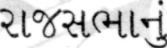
રાજસભાનું
